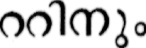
ററിനും
